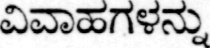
ವಿವಾಹಗಳನ್ನು
